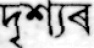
দৃশ্যৰ
